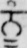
ਨੂੰ
